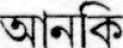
আনকি
